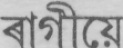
ৰাগীয়ে
